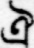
ঐ
